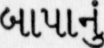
બાપાનું
